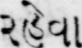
રહેવા
